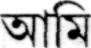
আমি
